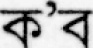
ক'ব
